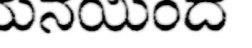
ಮನೆಯಿಂದ
